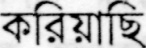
করিয়াছি
